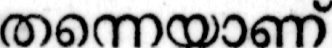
തന്നെയാണ്
